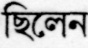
ছিলেন
